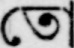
তো
